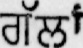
ਗੱਲਾਂ
